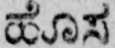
ಹೊಸ
